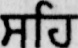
ਸਹਿ
